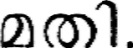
മതി.
